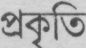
প্রকৃতি
